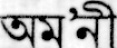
অম’নী
